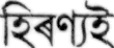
হিৰণ্যই
